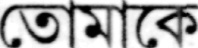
তোমাকে
